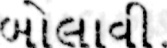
બોલાવી.
